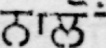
ਨਾਲੋਂ
